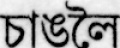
চাঙলৈ
